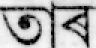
তাৰ
